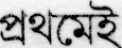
প্রথমেই
